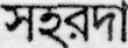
সহরদা
